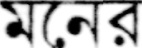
মনের
